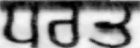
ਧਰਤ
